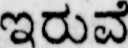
ಇರುವೆ
